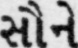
સૌને
